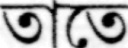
তাতে
